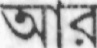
আর
